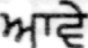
ਆਵੇ
